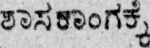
ಶಾಸಕಾಂಗಕ್ಕೆ
